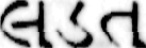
લડત
